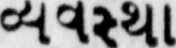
વ્યવસ્થા
